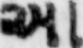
આ
